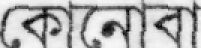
কোনোবা
